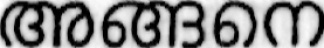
അങ്ങനെ
